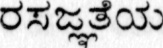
ರಸಜ್ಞತೆಯ
